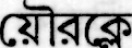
য়ৌরক্লে
